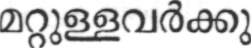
മറ്റുള്ളവര്‍ക്കു
